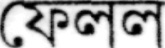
ফেলল
